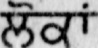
ਲੋਕਾਂ
